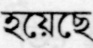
হয়েছে
